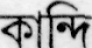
কান্দি
